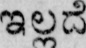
ಇಲ್ಲದೆ
